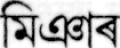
মিঞাৰ
